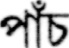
পাঁচ
